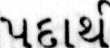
પદાર્થ
